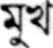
মুখ
